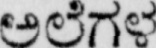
ಅಲೆಗಳ
